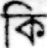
কি
